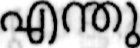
എന്തു
